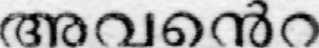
അവന്റെ
